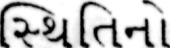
સ્થિતિનો
